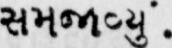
સમજાવ્યું.
